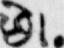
છો.
